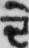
ਦੇ
